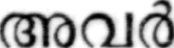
അവര്‍
